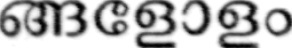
ങ്ങളോളം
